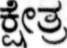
ಕ್ಷೇತ್ರ
